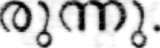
രുന്നു.
